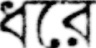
ধরে
